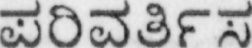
ಪರಿವರ್ತಿಸ
